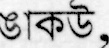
ঙাকউ,
